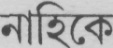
নাহিকে
